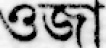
ওজা
